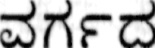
ವರ್ಗದ
